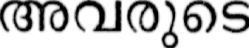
അവരുടെ
